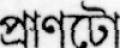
প্ৰাণটো
